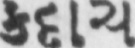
કદાચ
